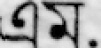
এম.
